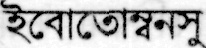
ইবোতোম্বনসু
